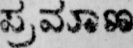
ಪ್ರಮಾಣ
